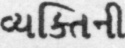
વ્યક્તિની
